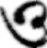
ও
